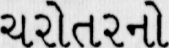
ચરોતર
